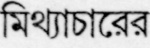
মিথ্যাচারের
